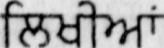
ਲਿਖੀਆਂ
